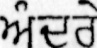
ਅੰਦਰੇ
